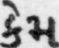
કેમ
